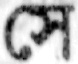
সে
